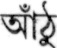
আঁঠু
